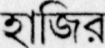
হাজির
